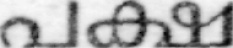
പക്ഷ
